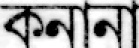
কনানা
